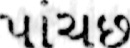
પાંચછ
